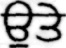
ਉਤੇ
